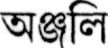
অঞ্জলি
